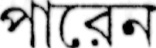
পারেন
